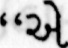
"એ
